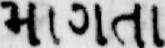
માગતા
